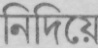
নিদিয়ে
